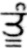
ਤੂੰ
